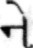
ને
